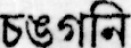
চঙগনি
